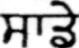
ਸਾਡੇ
